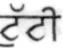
ਟੁੱਟੀ
